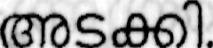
അടക്കി.
